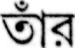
তাঁর
